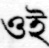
ওই
